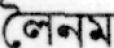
লৈনম
